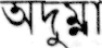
অদুম্না
